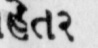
બહેતર
